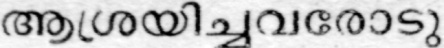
ആശ്രയിച്ചവരോടു
